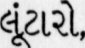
લૂંટારો,
